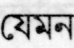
যেমন
